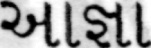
આજ્ઞા
